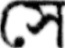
সে
